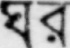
ঘর
